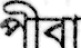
পীবা
